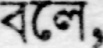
বলে,
